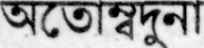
অতোম্বদুনা
